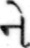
ને
